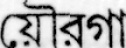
য়ৌরগা
